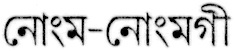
নোংম-নোংমগী
